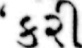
'કરી
